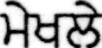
ਮੇਖਲੇ
